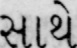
સાથે
